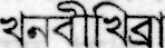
খনবীখিব্রা
